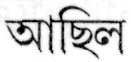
আছিল
